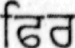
ਫਿਰ
